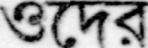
ওদের
